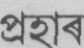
প্ৰহাৰ
